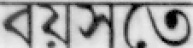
বয়সতে
